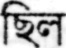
ছিল
